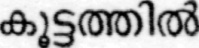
കൂട്ടത്തില്‍
